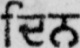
ਦਿਨ
